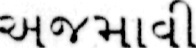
અજમાવી
